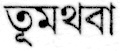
তুমথবা
